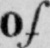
of
